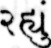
રહ્યું
